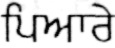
ਪਿਆਰੇ
